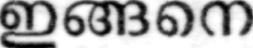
ഇങ്ങനെ
